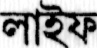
লাইফ
